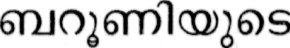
ബറൂണിയുടെ
